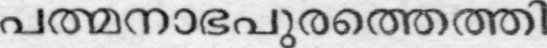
പത്മനാഭപുരത്തെത്തി
